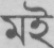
মই
